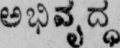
ಅಭಿವೃದ್ಧ
